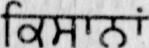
ਕਿਸਾਨਾਂ
